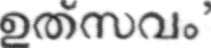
ഉത്സവം’
